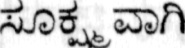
ಸೂಕ್ಷ್ಮವಾಗಿ
